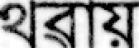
থৱায়
